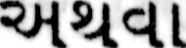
અથવા
